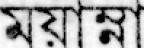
ময়াম্না
